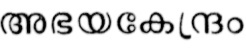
അഭയകേന്ദ്രം
